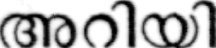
അറിയി
